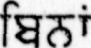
ਬਿਨਾਂ
